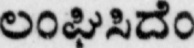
ಲಂಘಿಸಿದೆಂ
